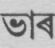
ভাৰ
